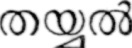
തയ്യല്‍
